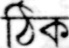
ঠিক
